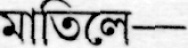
মাতিলে-
